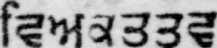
ਵਿਅਕਤਤਵ
